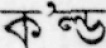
ক'ল্ড
